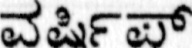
ವರ್ಷಿಪ್
